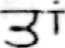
ਤਾਂ
